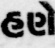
હણે
